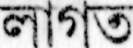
লাগত
